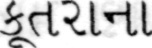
કૂતરાના
